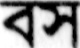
বস
